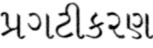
પ્રગટીકરણ
